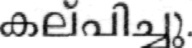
കല്പിച്ചു.
